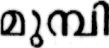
മുമ്പി
